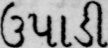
ઉપાડી
